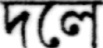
দলে
